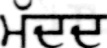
ਮੱਦਦ
